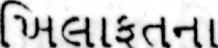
ખિલાફતના
